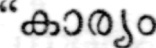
“കാര്യം
